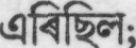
এৰিছিল;
